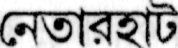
নেতারহাট
